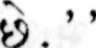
છે."
